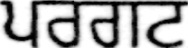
ਪਰਗਟ
